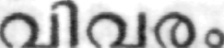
വിവരം
